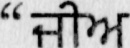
''ਜੀਅ
